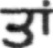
ਤਾਂ
